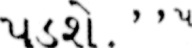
પડશે."૫
